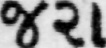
જરા
